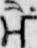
ਮੈਂ
